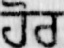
ਹੋਰ
